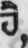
ਹੈ,
